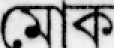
মোক
